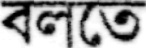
বলতে
